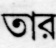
তার
